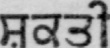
ਸ਼ਕਤੀ
